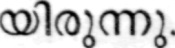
യിരുന്നു.
